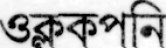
ওক্লকপনি
